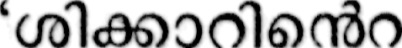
‘ശിക്കാറിന്റെ
